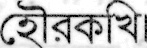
হৌরকখি।
